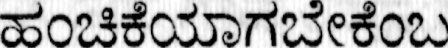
ಹಂಚಿಕೆಯಾಗಬೇಕೆಂಬ
